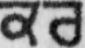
ਕਰ
